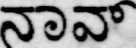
ನಾವ್
